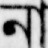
না
